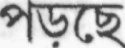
পড়ছে
